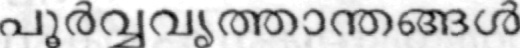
പൂര്‍വ്വവൃത്താന്തങ്ങള്‍
